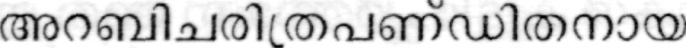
അറബിചരിത്രപണ്ഡിതനായ
